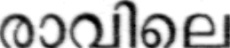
രാവിലെ
